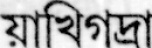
য়াখিগদ্রা
